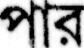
পার
